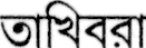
তাখিবরা
